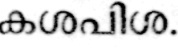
കശപിശ.
